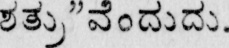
ಶತ್ರು”ವೆಂದುದು.
